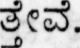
ತ್ತೇವೆ.
